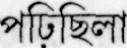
পঢ়িছিলা
